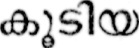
കൂടിയ
